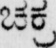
ಚಕ್ರ
